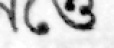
নত্তে
